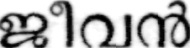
ജീവന്‍
